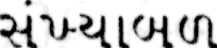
સંખ્યાબળ
